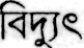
বিদ্যুৎ
